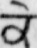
ਕੇ
